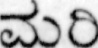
ಮರಿ
